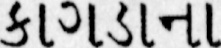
કાગડાના
